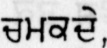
ਚਮਕਦੇ,
